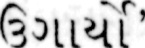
ઉગાર્યો.'
